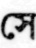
সে
